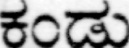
ಕಂಡು
